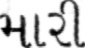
મારી
